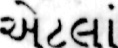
એટલાં
